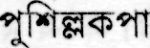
পুশিল্লকপা
